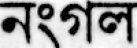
নংগল
